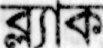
ব্ল্যাক
